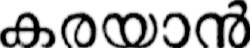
കരയാന്‍
